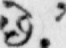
છે.'
